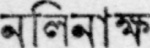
নলিনাক্ষ
